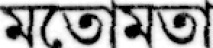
মতোমতা
